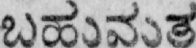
ಬಹುಮತ
